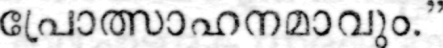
പ്രോത്സാഹനമാവും.”
